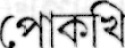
পোকখি
